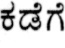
ಕಡೆಗೆ
